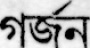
গর্জন
